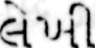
લેખી
